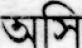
অসি
